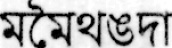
মমৈথঙদা
